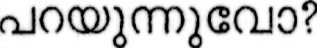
പറയുന്നുവോ?
